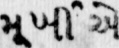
મૂખીંએ
